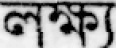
লক্ষ্য
